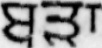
ਬੜਾ
